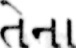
તેના
